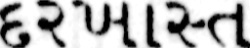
દરખાસ્ત
